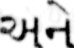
અને
